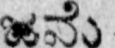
ಜಮೆ
